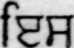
ਇਸ
